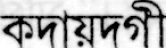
কদায়দগী
